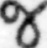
જ
